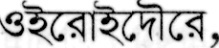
ওইরোইদৌরে,
